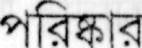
পরিষ্কার
